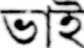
ভাই
